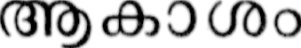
ആകാശം
